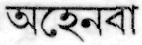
অহেনবা
